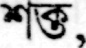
শক্ত,
